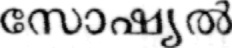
സോഷ്യല്‍
